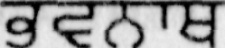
ਭਵਨਾਥ
